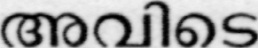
അവിടെ
